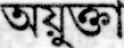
অয়ুক্তা
